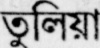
তুলিয়া
